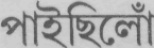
পাইছিলোঁ
